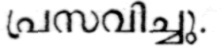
പ്രസവിച്ചു.
